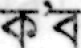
ক'ব
